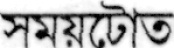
সময়টোত
